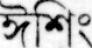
ঈশিং
